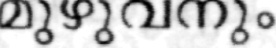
മുഴുവനും
